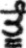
ਤੂੰ
